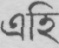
এহি
